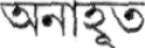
অনাহূত
